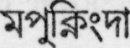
মপুক্নিংদা
